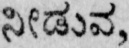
ನೀಡುವ,
